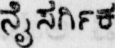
ನೈಸರ್ಗಿಕ
